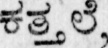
ಕತ್ತಲೆ,
